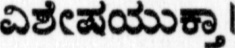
ವಿಶೇಷಯುಕ್ತಾ|
